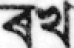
ৰখ
